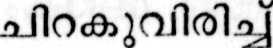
ചിറകുവിരിച്ച്
